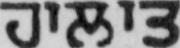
ਹਾਲਾਤ
